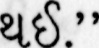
થઈ."
